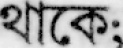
থাকে;
